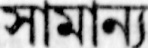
সামান্য
